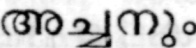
അച്ചനും
